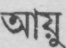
আয়ু
